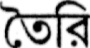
তৈরি
